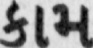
કામ
